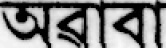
অৱাবা
